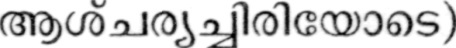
ആശ്ചര്യച്ചിരിയോടെ)
